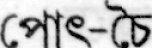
পোৎ-চৈ
